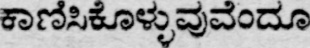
ಕಾಣಿಸಿಕೊಳ್ಳುವುವೆ೦ದೂ
